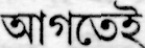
আগতেই
